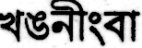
খঙনীংবা
